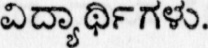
ವಿದ್ಯಾರ್ಥಿಗಳು.
